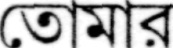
তোমার
